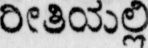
ರೀತಿಯಲ್ಲಿ
